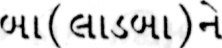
બા(લાડબા)ને
